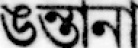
ঙন্তানা
